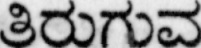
ತಿರುಗುವ
